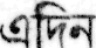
এদিন
